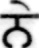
ਨੇ
